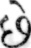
છે
